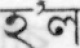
হ'ল
